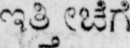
ಇತ್ತೀಚೆಗೆ
